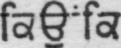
ਕਿਉਂਕਿ
